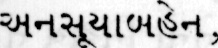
અનસૂયાબહેન,
